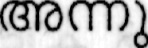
അന്നു
